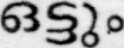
ഒട്ടും
